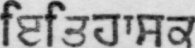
ਇਤਿਹਾਸਕ
